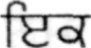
ਇਕ
